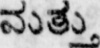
ಮತ್ತು
